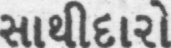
સાથીદારો
